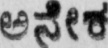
ಅನೇಕ
